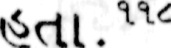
હતા.૧૧૮
